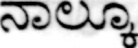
ನಾಲ್ಕೂ
